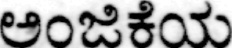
ಅಂಜಿಕೆಯ
